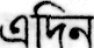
এদিন
